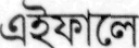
এইফালে
